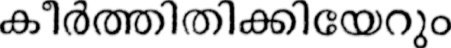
കീര്‍ത്തിതിക്കിയേറും
